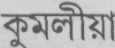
কুমলীয়া
